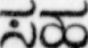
ಸಹ
